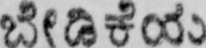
ಬೇಡಿಕೆಯ
